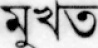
মুখত
